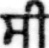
ਸੀ
